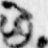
છે.
